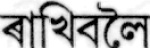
ৰাখিবলৈ
